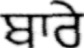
ਬਾਰੇ
